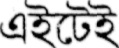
এইটেই
